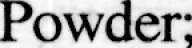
Powder;
